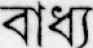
বাধ্য
